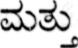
ಮತ್ತು
